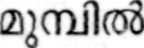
മുമ്പില്‍
